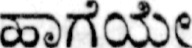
ಹಾಗೆಯೇ
